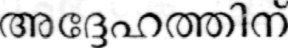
അദ്ദേഹത്തിന്
